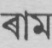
ৰাম
